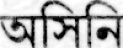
অসিনি
